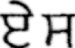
ਏਸ
